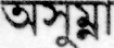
অসুম্না
